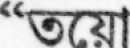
"তয়ো
